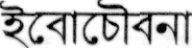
ইবোচৌবনা
